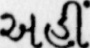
અહીં
